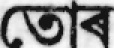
তোৰ
